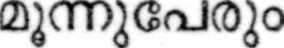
മൂന്നുപേരും
